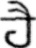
ਹੈ
